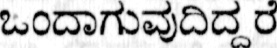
ಒಂದಾಗುವುದಿದ್ದರೆ
